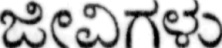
ಜೀವಿಗಳು
